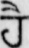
ਹੈ
